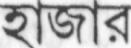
হাজার
